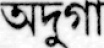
অদুগা
